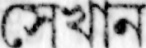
সেখান
